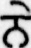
ਨੇ
